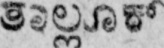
ತಾಲ್ಲೂಕ್
